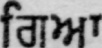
ਗਿਆ
